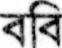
ববি
